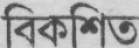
বিকশিত
